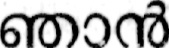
ഞാന്‍
